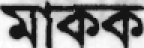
মাকক
